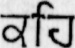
ਕਹਿ
